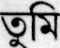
তুমি
